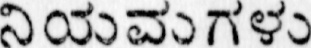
ನಿಯಮಗಳು
